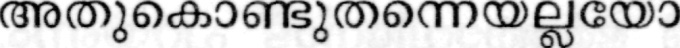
അതുകൊണ്ടുതന്നെയല്ലയോ
